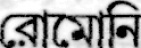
রোমোনি
